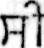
ਸੀ
